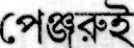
পেঞ্জরুই
